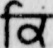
ਕਿ
